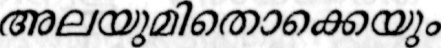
അലയുമിതൊക്കെയും
